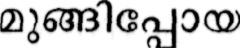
മുങ്ങിപ്പോയ
